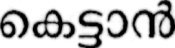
കെട്ടാന്‍
